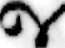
જ
